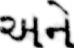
અને
